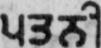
ਪਤਨੀ
